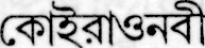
কোইরাওনবী
